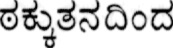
ಠಕ್ಕುತನದಿಂದ
